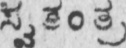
ಸ್ವತಂತ್ರ
